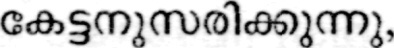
കേട്ടനുസരിക്കുന്നു,
